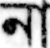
না
